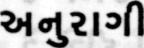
અનુરાગી
